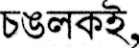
চঙলকই,
